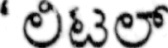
'ಲಿಟಲ್
